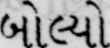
બોલ્યો
